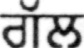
ਗੱਲ
